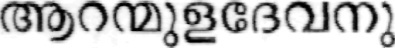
ആറന്മുളദേവനു
